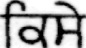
ਕਿਸੇ
